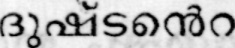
ദുഷ്ടന്റെ
